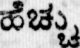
ಹೆಚ್ಚು
